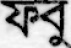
ফবু
